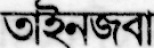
তাইনজবা
